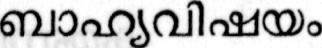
ബാഹ്യവിഷയം
